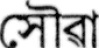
সৌৱা
